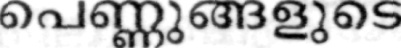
പെണ്ണുങ്ങളുടെ
